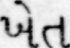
ખેત
